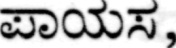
ಪಾಯಸ,
